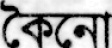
কৈনো
